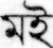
মই
